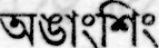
অঙাংশিং
